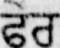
ਫੇਰ
